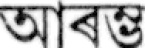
আৰম্ভ
